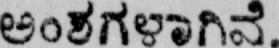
ಅಂಶಗಳಾಗಿವೆ.
